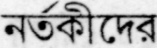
নর্তকীদের
